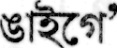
ঙাইগে’
